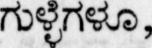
ಗುಳ್ಳೆಗಳೂ,
